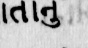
પોતાનું
